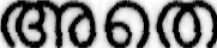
അതെ
